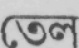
তেল
